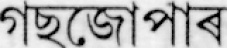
গছজোপাৰ
